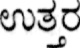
ಉತ್ತರ
